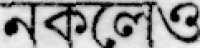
নকলেও
